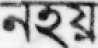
নহয়
